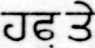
ਹਫ਼ਤੇ
